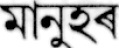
মানুহৰ
